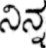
ನಿನ್ನ
